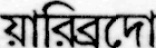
য়ারিব্রদো
